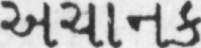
અચાનક
